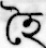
হৈ
